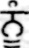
ਨੂੰ
